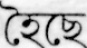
হৈছে
